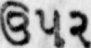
ઉપર
